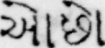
ઓછો
